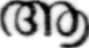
ആ
